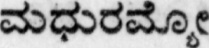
ಮಧುರಮ್ಯೋ
